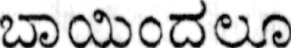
ಬಾಯಿಂದಲೂ
